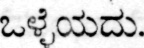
ಒಳ್ಳೆಯದು.
